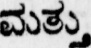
ಮತ್ತು
